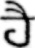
ਹੈ
